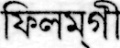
ফিলমগী
